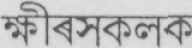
ক্ষীৰসকলক
